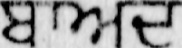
ਬਾਅਦ
